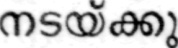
നടയ്ക്കു
